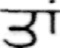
ਤਾਂ
